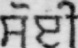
ਸੋਈ
